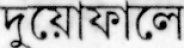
দুয়োফালে
